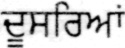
ਦੂਸਰਿਆਂ
